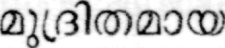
മുദ്രിതമായ
